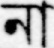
না
